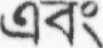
এবং
